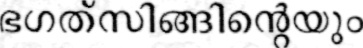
ഭഗത്സിങ്ങിന്റെയും
